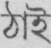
ঠাই
